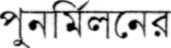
পুনর্মিলনের
